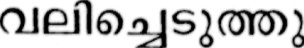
വലിച്ചെടുത്തു
